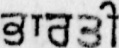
ਭਾਰਤੀ
